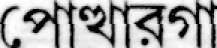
পোত্থারগা
